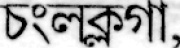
চংলক্লগা,
